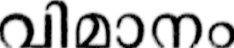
വിമാനം
